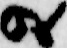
જ
